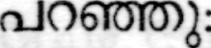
പറഞ്ഞു:
